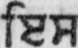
ਇਸ
